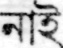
নাই
